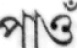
পাওঁ
